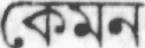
কেমন
